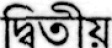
দ্বিতীয়
